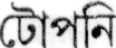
টোপনি
